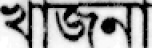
খাজনা
